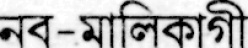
নব-মালিকাগী
